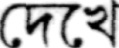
দেখে
